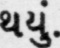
થયું.
